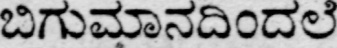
ಬಿಗುಮಾನದಿಂದಲೆ
